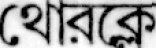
থোরক্লে
